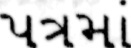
પત્રમાં
